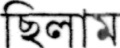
ছিলাম
